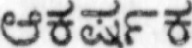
ಆಕರ್ಷಕ
